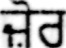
ਜ਼ੋਰ
